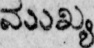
ಮುಖ್ಯ
